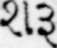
શરૂ
